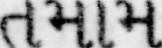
તમામ
